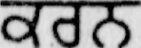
ਕਰਨ
